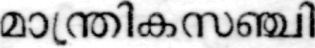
മാന്ത്രികസഞ്ചി
